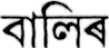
বালিৰ
